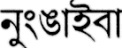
নুংঙাইবা
